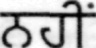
ਨਹੀਂ
